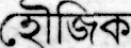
হৌজিক
